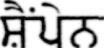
ਸ਼ੈਂਪੇਨ
